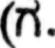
(ಗ.
